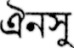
ঐনসু
